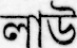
লাউ
